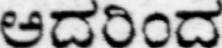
ಅದರಿಂದ
